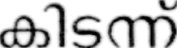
കിടന്ന്
